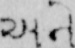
અને
